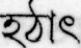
হঠাৎ
